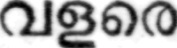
വളരെ
